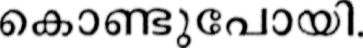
കൊണ്ടുപോയി.
